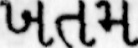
ખતમ
